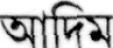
আদিম
